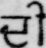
ਦੀ
